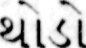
થોડો
